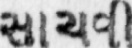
સાચવી
